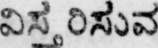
ವಿಸ್ತರಿಸುವ
